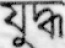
যুদ্ধ
